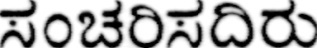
ಸಂಚರಿಸದಿರು
